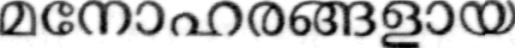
മനോഹരങ്ങളായ
